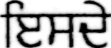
ਇਸਦੇ
